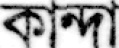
কান্দা
